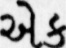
એક
